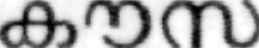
കൌസ
